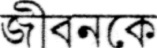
জীবনকে
